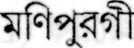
মণিপুরগী
